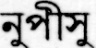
নুপীসু
